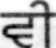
ਵੀ
